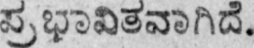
ಪ್ರಭಾವಿತವಾಗಿದೆ.
